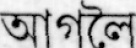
আগলৈ
